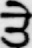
ਤੇ
